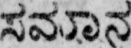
ಸಮಾನ
